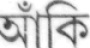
আঁকি
